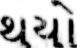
થયો
